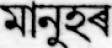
মানুহৰ
